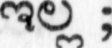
ಇಲ್ಲ;
